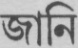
জানি
